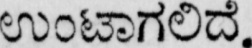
ಉಂಟಾಗಲಿದೆ.
